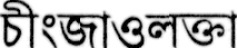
চীংজাওলক্তা
